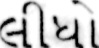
લીધો
